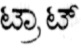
ಟ್ರಾಟ್
